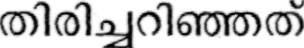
തിരിച്ചറിഞ്ഞത്
